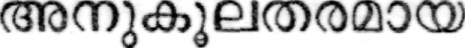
അനുകൂലതരമായ
